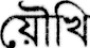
য়ৌখি
